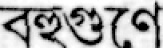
বহুগুণে
